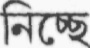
নিচ্ছে
